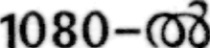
1080-ല്‍
